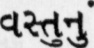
વસ્તુનું
